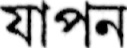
যাপন
